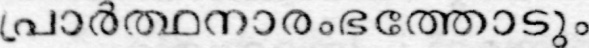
പ്രാര്‍ത്ഥനാരംഭത്തോടും
